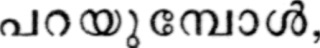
പറയുമ്പോള്‍,
